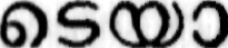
ടെയാ
